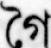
গৈ
